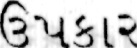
ઉપકાર
